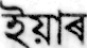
ইয়াৰ
